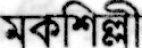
মকশিল্লী
